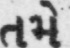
તમે
